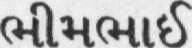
ભીમભાઈ
